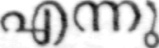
എന്നു
